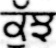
ਕੁੱਝ
